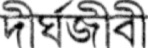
দীর্ঘজীবী
